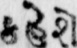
કહેશે
